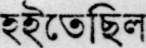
হইতেছিল
